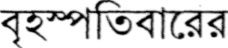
বৃহস্পতিবারের
